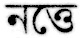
নত্তে
